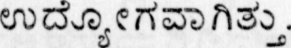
ಉದ್ಯೋಗವಾಗಿತ್ತು.
